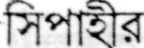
সিপাহীর
